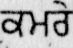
ਕਮਰੇ
